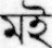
মই
